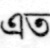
এত
